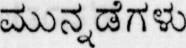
ಮುನ್ನಡೆಗಳು
